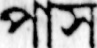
পাস
